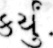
કર્યું.
